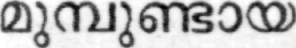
മുമ്പുണ്ടായ
